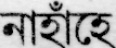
নাহাঁহে
